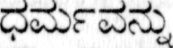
ಧರ್ಮವನ್ನು
